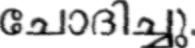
ചോദിച്ചു.
